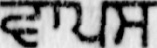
ਵਾਪਸ
